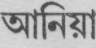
আনিয়া
